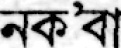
নক'বা
